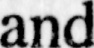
and
